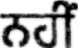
ਨਹੀਂ
